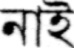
নাই
